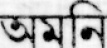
অমনি
